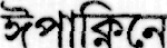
ঈপাক্নিনে
